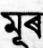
মূৰ
